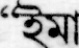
“ইমা
